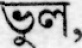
ভুল,
